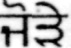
ਜੋੜੇ
